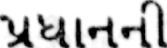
પ્રધાનની
